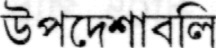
উপদেশাবলি
